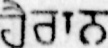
ਹੈਰਾਨ
